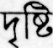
দৃষ্টি
